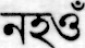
নহওঁ
